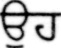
ਉਹ
